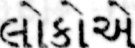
લોકોએ
